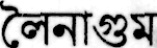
লৈনাগুম
